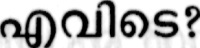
എവിടെ?
